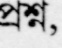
প্রশ্ন,
